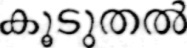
കൂടുതല്‍
